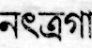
নৎত্রগা
